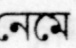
নেমে
